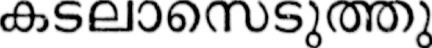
കടലാസെടുത്തു
